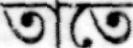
তাতে
